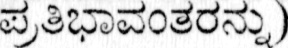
ಪ್ರತಿಭಾವಂತರನ್ನು)
